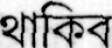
থাকিব
